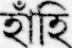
হাঁহি
